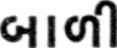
બાળી
